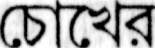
চোখের
